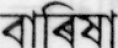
বাৰিষা
